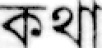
কথা
